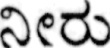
ನೀರು
